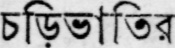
চড়িভাতির
